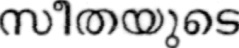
സീതയുടെ
